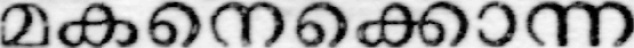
മകനെക്കൊന്ന
